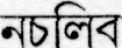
নচলিব
